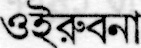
ওইরুবনা
